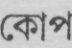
কোপ
